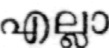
എല്ലാ
